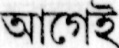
আগেই
